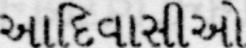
આદિવાસીઓ
